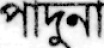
পাদুনা
